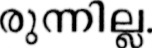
രുന്നില്ല.
